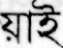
য়াই
